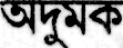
অদুমক
